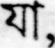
যা,
